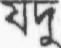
যদু
